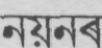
নয়নৰ
